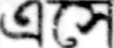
এসে
